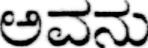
ಅವನು
